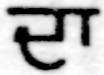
ਦਾ
